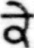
ਕੇ
